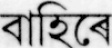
বাহিৰে
